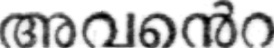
അവന്റെ
